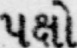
પક્ષો
